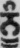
ਨੂੰ
